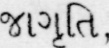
જાગૃતિ,
